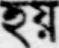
হয়
